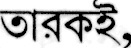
তারকই,
